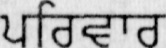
ਪਰਿਵਾਰ
